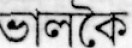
ভালকৈ
